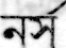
নর্স
